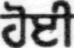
ਹੋਈ
